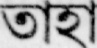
তাহা
